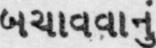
બચાવવાનું
